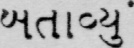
બતાવ્યું
